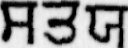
ਸਤਯ
